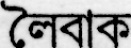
লৈবাক
